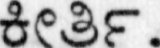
ಕೀರ್ತಿ,
